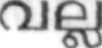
വല്ല
